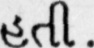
હતી.
